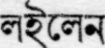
লইলেন
